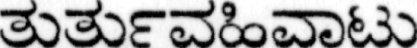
ತುರ್ತುವಹಿವಾಟು
